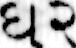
ઘર
